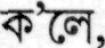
ক'লে,
